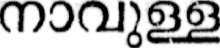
നാവുള്ള
